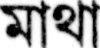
মাথা
